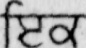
ਇਕ
